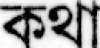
কথা
